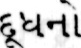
દૂધનો
